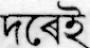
দৰেই
